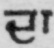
ਦਾ
